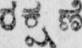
ರಕ್ಷಣೆ
